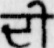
ਦੀ
